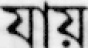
যায়
